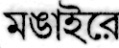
মঙাইরে
